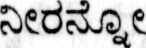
ನೀರನ್ನೋ
